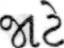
જાટે
